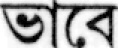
ভাবে
